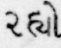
રહ્યો
